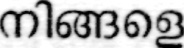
നിങ്ങളെ
